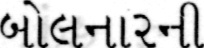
બોલનારની
